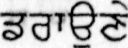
ਡਰਾਉਣੇ
